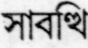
সাবত্থি
